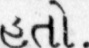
હતો.
